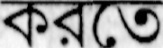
করতে
